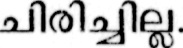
ചിരിച്ചില്ല.
